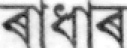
ৰাধাৰ
